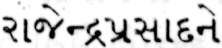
રાજેન્દ્રપ્રસાદને
